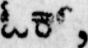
ಓಕ್,
